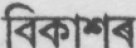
বিকাশৰ
